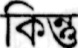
কিন্তু
